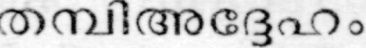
തമ്പിഅദ്ദേഹം
